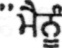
''ਮੈਨੂੰ
